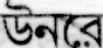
উনরে
